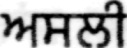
ਅਸਲੀ
